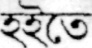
হইতে
